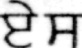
ਏਸ
